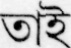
তাই
